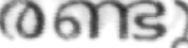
രണ്ടു
